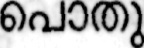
പൊതു
